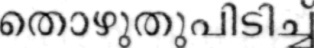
തൊഴുതുപിടിച്ച്
